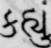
કહ્યું
